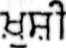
ਖ਼ੁਸ਼ੀ
